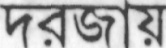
দরজায়
